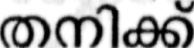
തനിക്ക്
